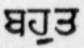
ਬਹੁਤ
